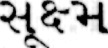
સૂક્ષ્મ
